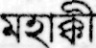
মহাক্কী
